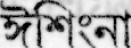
ঈশিংনা
